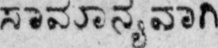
ಸಾಮಾನ್ಯವಾಗಿ
